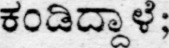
ಕಂಡಿದ್ದಾಳೆ;
